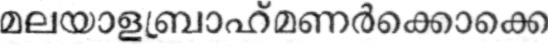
മലയാളബ്രാഹ്മണര്‍ക്കൊക്കെ
